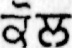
ਕੋਲ
